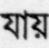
যায়
